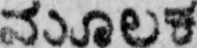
ಮೂಲಕ
